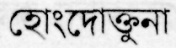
হোংদোক্তুনা
